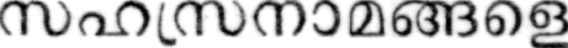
സഹസ്രനാമങ്ങളെ
